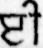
ਈ
